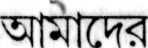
আমাদের
